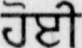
ਹੋਈ
